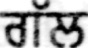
ਗੱਲ
